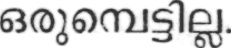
ഒരുമ്പെട്ടില്ല.
